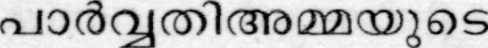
പാര്‍വ്വതിഅമ്മയുടെ
